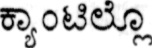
ಕ್ಯಾಂಟಿಲ್ಲೊ
